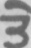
ਤੇ
